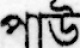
পাউ
